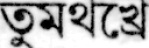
তুমথখ্রে
